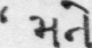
'મને
